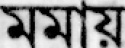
মমায়
